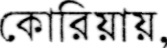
কোরিয়ায়,
